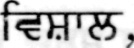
ਵਿਸ਼ਾਲ,
